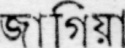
জাগিয়া
